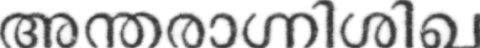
അന്തരാഗ്നിശിഖ
